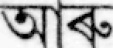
আৰু
